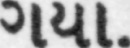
ગયા.
